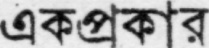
একপ্রকার
